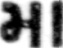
મા
